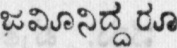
ಜಮೀನಿದ್ದರೂ
